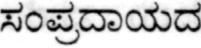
ಸಂಪ್ರದಾಯದ
